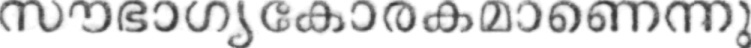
സൌഭാഗ്യകോരകമാണെന്നു
